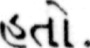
હતો.
